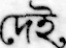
দেই,
